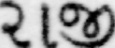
રાજી
